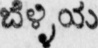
ಬೆಳ್ಳಿಯ
